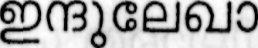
ഇന്ദുലേഖാ
